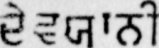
ਦੇਵਯਾਨੀ
